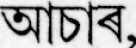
আচাৰ,
